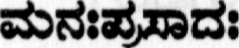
ಮನಃಪ್ರಸಾದಃ
